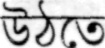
উঠতে
